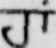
ਹਾਂ
